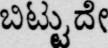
ಬಿಟ್ಟುದೇ
